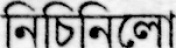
নিচিনিলো
